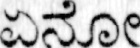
ಏನೋ
